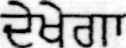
ਦੇਖੇਗਾ
